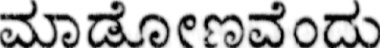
ಮಾಡೋಣವೆಂದು
